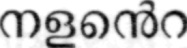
നളന്റെ
